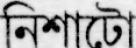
নিশাটো
